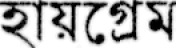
হায়গ্রেম
